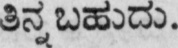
ತಿನ್ನಬಹುದು.
